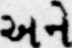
અને
